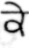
ਕੇ
